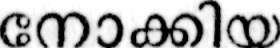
നോക്കിയ
